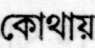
কোথায়
